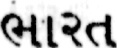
ભારત
